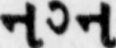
નગ્ન
